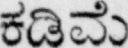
ಕಡಿಮೆ
